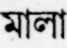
মালা
